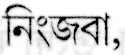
নিংজবা,
